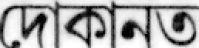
দোকানত
